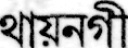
থায়নগী
